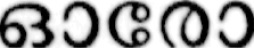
ഓരോ
